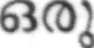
ഒരു
